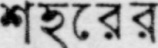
শহরের
